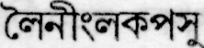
লৈনীংলকপসু
